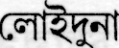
লোইদুনা
